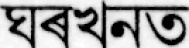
ঘৰখনত
